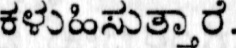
ಕಳುಹಿಸುತ್ತಾರೆ.
